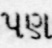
પણ
